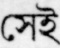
সেই
